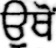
ਉਥੋਂ
